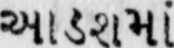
આડશમાં
